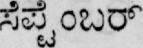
ಸೆಪ್ಟೆಂಬರ್
